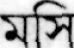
মসি
